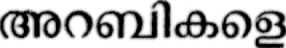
അറബികളെ
